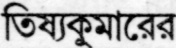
তিষ্যকুমারের
